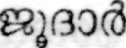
ജൂദാര്‍
